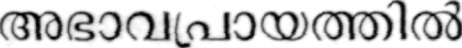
അഭാവപ്രായത്തില്‍
